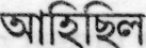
আহিছিল
